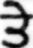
ਤੇ
